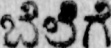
ಬೆಲೆಗೆ
